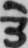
ਤੇ
